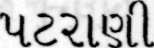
પટરાણી
